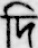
দি
